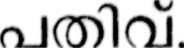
പതിവ്.
